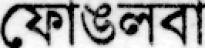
ফোঙলবা
